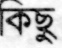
কিছু
